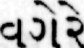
વગેરે
